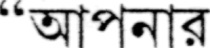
“আপনার
